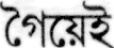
গৈয়েই
